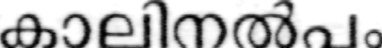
കാലിനല്‍പം
